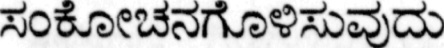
ಸಂಕೋಚನಗೊಳಿಸುವುದು
